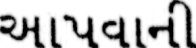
આપવાની
